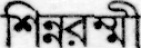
শিন্নরম্মী
